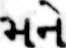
મને
